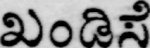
ಖಂಡಿಸೆ
